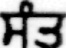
ਸੰਤ
